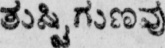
ತುಷ್ಟಿಗುಣವು
